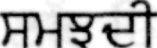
ਸਮਝਦੀ
